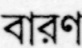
বারণ
